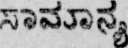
ಸಾಮಾನ್ಯ
